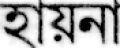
হায়না
